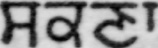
ਸਕਣਾ
